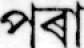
পৰা
